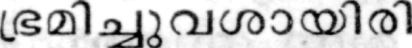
ഭ്രമിച്ചുവശായിരി
